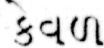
કેવળ
